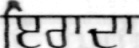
ਇਰਾਦਾ
